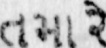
તમારે
